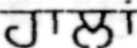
ਹਾਲਾਂ
